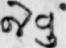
જેવું
